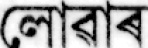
লোৱাৰ
